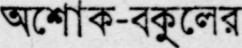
অশোক-বকুলের
